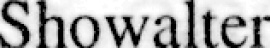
Showaler
